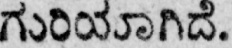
ಗುರಿಯಾಗಿದೆ.
